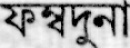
ফম্বদুনা
